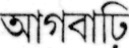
আগবাঢ়ি
